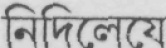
নিদিলেযে
